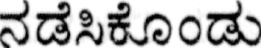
ನಡೆಸಿಕೊಂಡು
